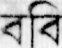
ববি
